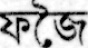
ফজৈ
